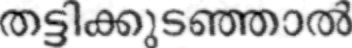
തട്ടിക്കുടഞ്ഞാല്‍
